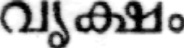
വൃക്ഷം
